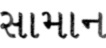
સામાન
